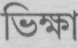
ভিক্ষা
